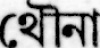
থৌনা
